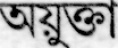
অয়ুক্তা
